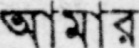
আমার
